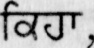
ਕਿਹਾ,
